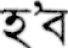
হ'ব
